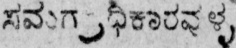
ಸಮಗ್ರಾಧಿಕಾರವುಳ್ಳ
